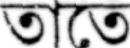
তাতে
